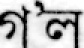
গ'ল
